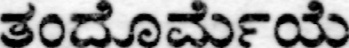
ತಂದೊರ್ಮೆಯೆ
